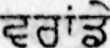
ਵਰਾਂਡੇ
